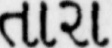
તારા
